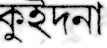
কুইদনা
